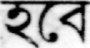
হবে
